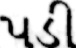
પડી
